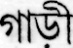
গাড়ী
